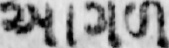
આગળ
